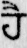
ਹੈ
